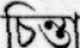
চিন্তা
